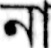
না
